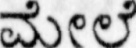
ಮೇಲೆ
